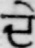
ਦੇ
